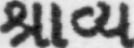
શ્રાવ્ય
